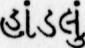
હાંડલું
